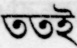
ততই
